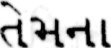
તેમના
